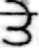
ਤੇ
